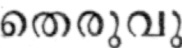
തെരുവു
